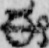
ಈ
